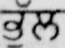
ਭੁੱਲ
